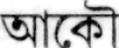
আকৌ
